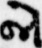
જો
